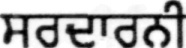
ਸਰਦਾਰਨੀ
